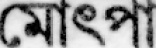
মোৎপদু
